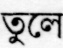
তুলে
